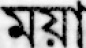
ময়া
